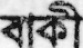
বাকী
